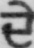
ਦੇ
